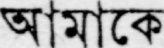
আমাকে
